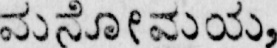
ಮನೋಮಯ,
